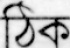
ঠিক
